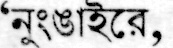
“নুংঙাইরে,
